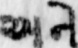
અને
